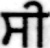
ਸੀ
